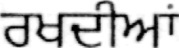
ਰਖਦੀਆਂ
